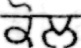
ਕੋਲ
